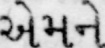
એમને
